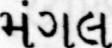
મંગલ
